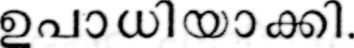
ഉപാധിയാക്കി.
